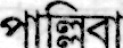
পাল্লিবা
